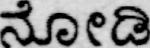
ನೋಡಿ
